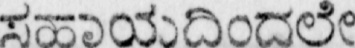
ಸಹಾಯದಿಂದಲೇ
